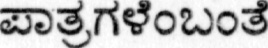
ಪಾತ್ರಗಳೆಂಬಂತೆ
